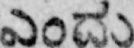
ಎಂದು
